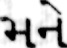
મને
